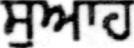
ਸੁਆਹ
